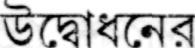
উদ্বোধনের
